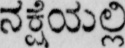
ನಕ್ಷೆಯಲ್ಲಿ
